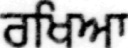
ਰਖਿਆ
